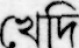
খেদি
